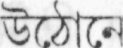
উঠোনে
